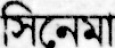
সিনেমা
